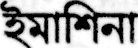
ইমাশিনা
